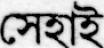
সেহাই
